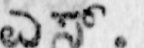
ಎಸ್.
